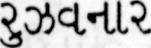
રુઝવનાર
